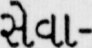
સેવા-
